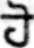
ਹੋ
